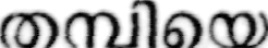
തമ്പിയെ
